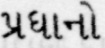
પ્રધાનો
